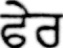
ਫੇਰ
